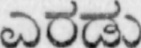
ಎರಡು
